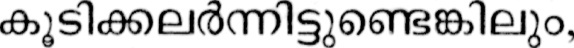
കൂടിക്കലര്‍ന്നിട്ടുണ്ടെങ്കിലും,
